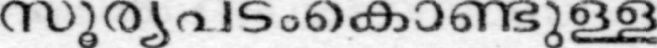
സൂര്യപടംകൊണ്ടുള്ള
